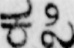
ಕಪಿ
